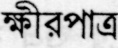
ক্ষীরপাত্র
